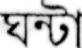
ঘন্টা
